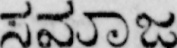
ಸಮಾಜ
